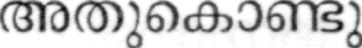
അതുകൊണ്ടു
